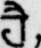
ਹੈ,
